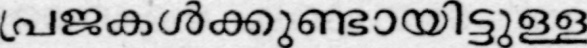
പ്രജകള്‍ക്കുണ്ടായിട്ടുള്ള
